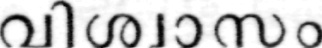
വിശ്വാസം
